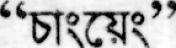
“চাংয়েং”
